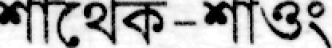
শাথেক-শাওং
